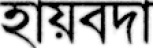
হায়বদী
